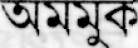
অমমুক
